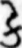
કે
